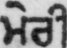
ਮੇਰੀ
